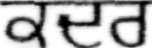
ਕਦਰ
